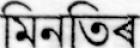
মিনতিৰ
